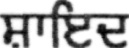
ਸ਼ਾਇਦ
